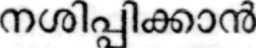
നശിപ്പിക്കാന്‍
